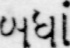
બધાં
